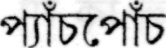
প্যাঁচপোঁচ
